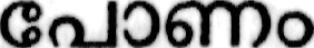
പോണം
